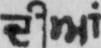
ਦੀਆਂ
